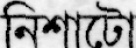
নিশাটো
